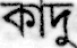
কাদু
